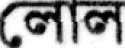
লোল
